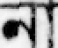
না
